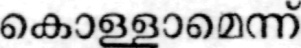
കൊള്ളാമെന്ന്
